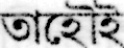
তাহৌই
